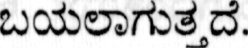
ಬಯಲಾಗುತ್ತದೆ.
